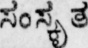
ಸಂಸ್ಕೃತ
